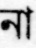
না
